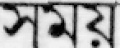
সময়
